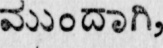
ಮುಂದಾಗಿ,
